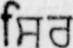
ਸਿਰ
